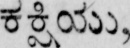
ಕಕ್ಷಿಯು,
